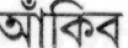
আঁকিব
